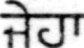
ਜੇਹਾ
